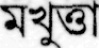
মখুত্তা
